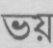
ভয়
